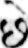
છે
